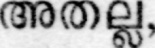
അതല്ല,
